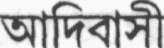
আদিবাসী
